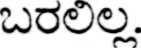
ಬರಲಿಲ್ಲ.
